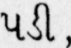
પડી,
